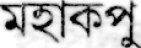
মহাকপু
